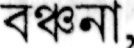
বঞ্চনা,
